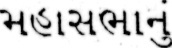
મહાસભાનું
